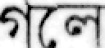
গলে
